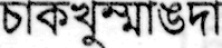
চাকখুম্মাঙদা
